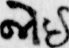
જોઈ
